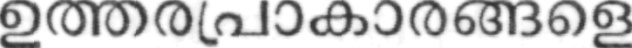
ഉത്തരപ്രാകാരങ്ങളെ
